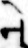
ને
